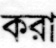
করা
